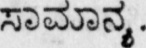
ಸಾಮಾನ್ಯ.
